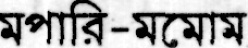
মপারি-মমোম
